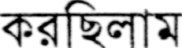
করছিলাম
